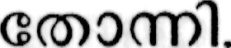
തോന്നി.
